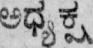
ಅಧ್ಯಕ್ಷ
